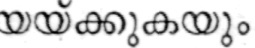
യയ്ക്കുകയും
